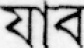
যাব
